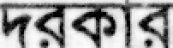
দরকার
